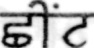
ਛੀਂਟ
